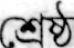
শ্ৰেষ্ঠ
